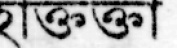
হাক্তক্তা
